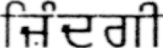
ਜ਼ਿੰਦਗੀ
